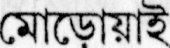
মোড়োয়াই
